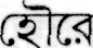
হৌরে
